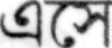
এসে
